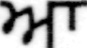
ਆ
